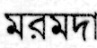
মরমদা
